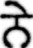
ਨੇ
